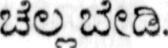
ಚೆಲ್ಲಬೇಡಿ.
